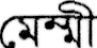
মেম্মী
